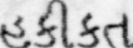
હકીકત
